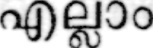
എല്ലാം
